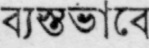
ব্যস্তভাবে
